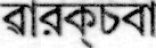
ৱারক্চবা
